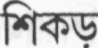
শিকড়
